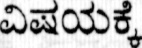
ವಿಷಯಕ್ಕೆ
